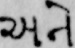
અને
